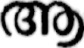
ആ
